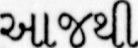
આજથી
